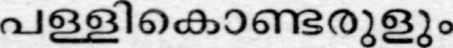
പള്ളികൊണ്ടരുളും
